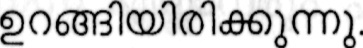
ഉറങ്ങിയിരിക്കുന്നു.
